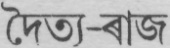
দৈত্য-ৰাজ
